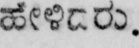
ಹೇಳಿದರು.
